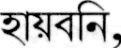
হায়বনি,
